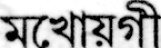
মখোয়গী
